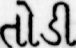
તોડી
